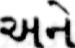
અને
